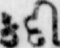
કદી
